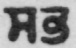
ਸਭ
